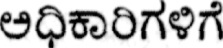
ಅಧಿಕಾರಿಗಳಿಗೆ
